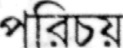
পরিচয়
